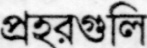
প্রহরগুলি
